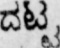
ದಟ್ಟ
